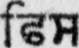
ਫਿਸ
